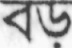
বড়
